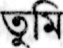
তুমি
